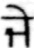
ਜੇ
